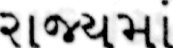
રાજ્યમાં
